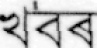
খবৰ
